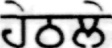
ਹੇਠਲੇ
